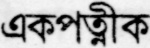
একপত্নীক
